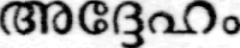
അദ്ദേഹം
